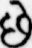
છે
